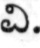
ವಿ.
